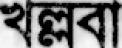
খল্লবা
